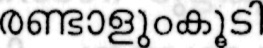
രണ്ടാളുംകൂടി
